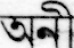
অনী
